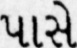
પાસે
